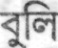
বুলি
